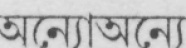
অন্যোঅন্যে
